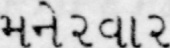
મનેરવાર
